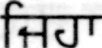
ਜਿਹਾ
